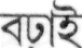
বঢ়াই
